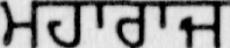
ਮਹਾਰਾਜ
